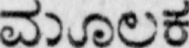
ಮೂಲಕ
